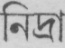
নিদ্ৰা
